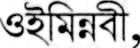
ওইমিন্নবী,
